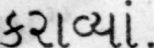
કરાવ્યાં.
